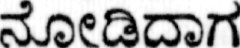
ನೋಡಿದಾಗ
